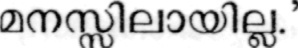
മനസ്സിലായില്ല.'
